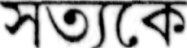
সত্যকে
